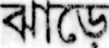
ঝাড়ে
